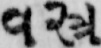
વસ્ત્ર
